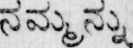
ನಮ್ಮನ್ನು
